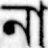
না
